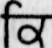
ਕਿ
